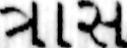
ત્રાસ
